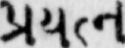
પ્રયત્ન
